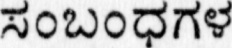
ಸಂಬಂಧಗಳ
